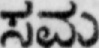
ಸಮ
